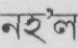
নহ'ল
